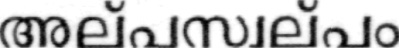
അല്പസ്വല്പം
